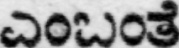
ಎಂಬಂತೆ
